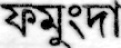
ফমুংদা
